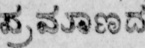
ಪ್ರಮಾಣದ
